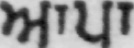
ਆਪਾ
